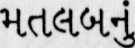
મતલબનું
